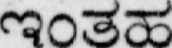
ಇಂತಹ
